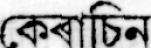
কেৰাচিন
